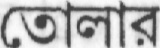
তোলার
